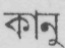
কানু
